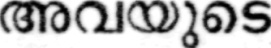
അവയുടെ
